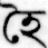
হৈ
